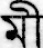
মী
